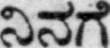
ನಿನಗೆ
